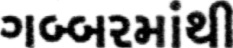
ગબ્બરમાંથી
